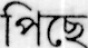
পিছে
